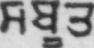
ਸਬੂਤ
